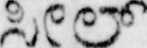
ಸೀಲ್
